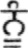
ਨੂੰ
